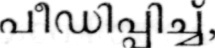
പീഡിപ്പിച്ച്,
